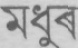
মধুৰ
